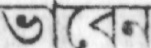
ভাবেন
